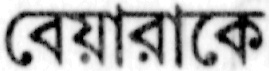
বেয়ারাকে
